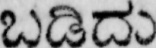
ಬಡಿದು
